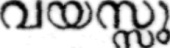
വയസ്സു
